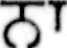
ਨਾ
